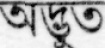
অদ্ভুত
